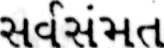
સર્વસંમત
